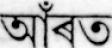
আঁৰত
